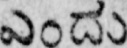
ಎಂದು
